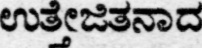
ಉತ್ತೇಜಿತನಾದ
